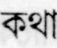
কথা
